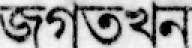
জগতখন
